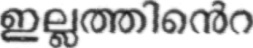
ഇല്ലത്തിന്റെ
